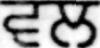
ਵਲ
